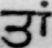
ਤਾਂ
